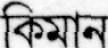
কিমান
